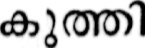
കുത്തി
